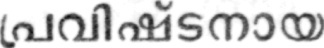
പ്രവിഷ്ടനായ
